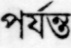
পর্যন্ত
